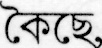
কৈছে,
